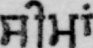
ਸੀਮਾਂ
